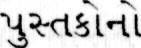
પુસ્તકોનો
